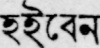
হইবেন
